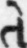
તે
